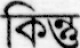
কিন্তু
